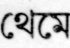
থেমে
